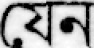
যেন
